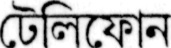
টেলিফোন
